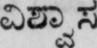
ವಿಶ್ವಾಸ
